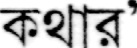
কথার’
